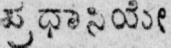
ಪ್ರಧಾನಿಯೇ
